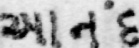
આનંદ
